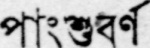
পাংশুবর্ণ
